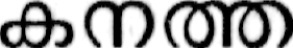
കനത്ത
